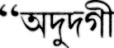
“অদুদগী
